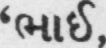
'ભાઈ,
